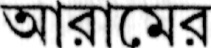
আরামের
